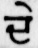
ਦੇ
